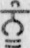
ਨੂੰ
